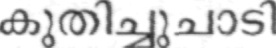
കുതിച്ചുചാടി
